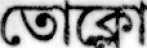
তোক্লো
